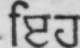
ਇਹ
